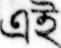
এই
